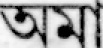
অমা
